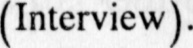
(Interview).
